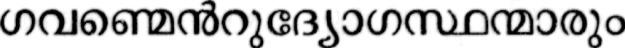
ഗവണ്മെൻ്‌റുദ്യോഗസ്ഥന്മാരും
